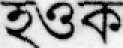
হওক
